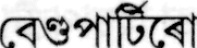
বেণ্ডপাৰ্টিৰো
